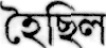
হৈছিল
